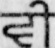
ਵੀ
